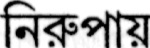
নিরুপায়
